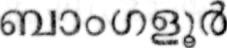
ബാംഗളൂര്‍
